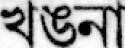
খঙনা
